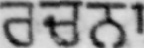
ਰਚਨਾ
